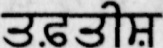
ਤਫ਼ਤੀਸ਼
